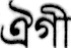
ঐগী
